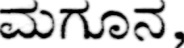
ಮಗೂನ,
